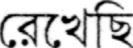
রেখেছি
